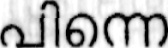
പിന്നെ
